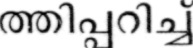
ത്തിപ്പറിച്ച്
